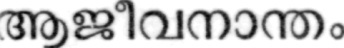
ആജീവനാന്തം
